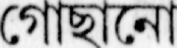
গোছানো
